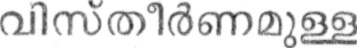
വിസ്തീര്‍ണമുള്ള
